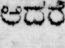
ಆದರೆ
